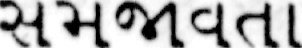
સમજાવતા
